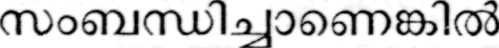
സംബന്ധിച്ചാണെങ്കില്‍
